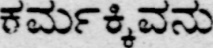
ಕರ್ಮಕ್ಕಿವನು
